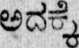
ಅದಕ್ಕೆ
